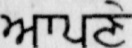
ਆਪਣੇ
